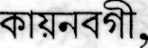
কায়নবগী,
